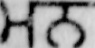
ਮਨ
